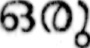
ഒരു
